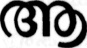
ആ
